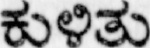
ಕುಳಿತು
